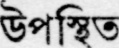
উপস্থিত
